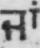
ਜਾਂ
